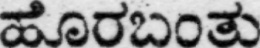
ಹೊರಬಂತು
